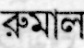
রুমাল
